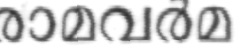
രാമവര്‍മ
